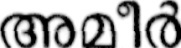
അമീര്‍
